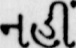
નહીં
